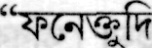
“ফনেক্তুদি
